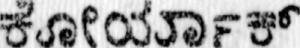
ಕೋರ್ಯಾಕ್
